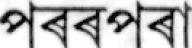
পৰৰপৰা
